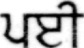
ਪਈ
